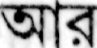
আর
